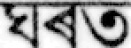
ঘৰত
